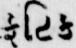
ફટિક
